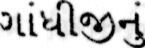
ગાંધીજીનું
